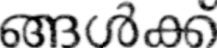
ങ്ങള്‍ക്ക്
